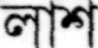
লাশ
